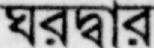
ঘরদ্বার
